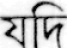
যদি
